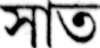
সাত
